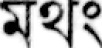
মথং
